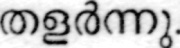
തളര്‍ന്നു.
